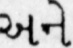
અને
